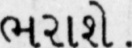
ભરાશે.
